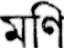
মণি
